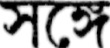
সঙ্গে
